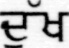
ਦੁੱਖ
